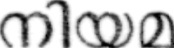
നിയമ
